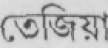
তেজিয়া
